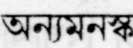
অন্যমনস্ক
